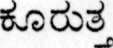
ಕೂರುತ್ತ
